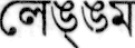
লেঙ্ঙম
